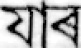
যাৰ
